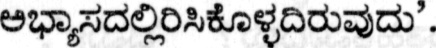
ಅಭ್ಯಾಸದಲ್ಲಿರಿಸಿಕೊಳ್ಳದಿರುವುದು'.
